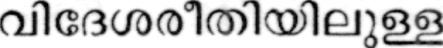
വിദേശരീതിയിലുള്ള
